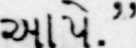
આપે."
